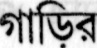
গাড়ির
